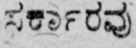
ಸರ್ಕಾರವು
